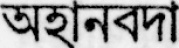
অহানবদা
